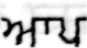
ਆਪ
